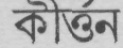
কীৰ্ত্তন
